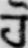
ਹੋ
